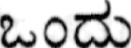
ಒಂದು
